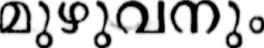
മുഴുവനും
